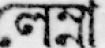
লেম্না
